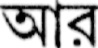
আর
